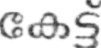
കേട്ട്
